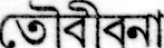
তৌবীবনা
